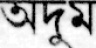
অদুম
